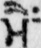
ਮੈਂ
